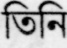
তিনি
